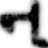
ન
